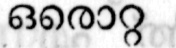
ഒരൊറ്റ
